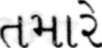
તમારે
